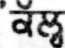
'ਕੱਲ੍ਹ
